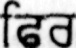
ਫਿਰ
